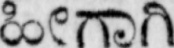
ಹೀಗಾಗಿ
